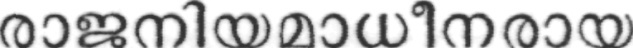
രാജനിയമാധീനരായ
